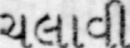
ચલાવી
